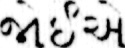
જોઈએ
